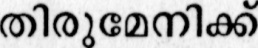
തിരുമേനിക്ക്
